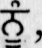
ਨੂੰ,
